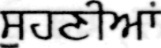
ਸੁਹਣੀਆਂ
